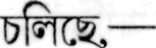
চলিছে,-
